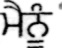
ਮੈਨੂੰ
